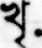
খৃ.
